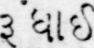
રૂંધાઈ
